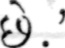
છે.'
